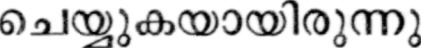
ചെയ്യുകയായിരുന്നു
